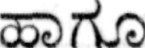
ಹಾಗೂ
